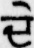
ਦੇ
